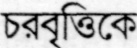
চরবৃত্তিকে
